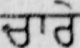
ਚਾਰੇ
